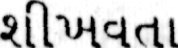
શીખવતા
